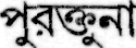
পুরক্তুনা
